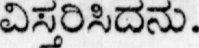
ವಿಸ್ತರಿಸಿದನು.
